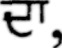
ਦਾ,
